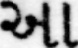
આ
